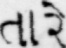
તારે
